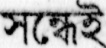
সন্ধেই
